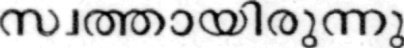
സ്വത്തായിരുന്നു
